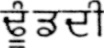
ਢੂੰਡਦੀ
